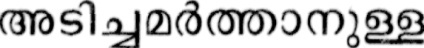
അടിച്ചമര്‍ത്താനുള്ള
